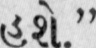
હશે."
